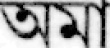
অমা
